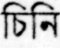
চিনি
